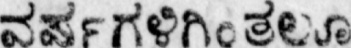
ವರ್ಷಗಳಿಗಿಂತಲೂ
